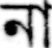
না
